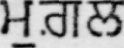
ਮੁਗ਼ਲ
